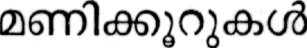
മണിക്കൂറുകള്‍
